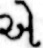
એ
